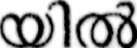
യില്‍
